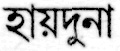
হায়দুনা
